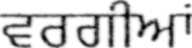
ਵਰਗੀਆਂ
